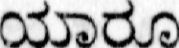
ಯಾರೂ
